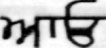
ਆਓ
